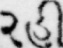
રહી
